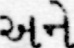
અને
